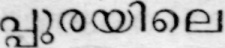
പ്പുരയിലെ
